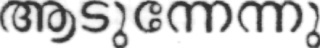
ആടുന്നേന്നു
